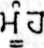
ਮੂੰਹ
